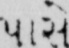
પાસે
